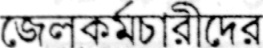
জেলকর্মচারীদের
